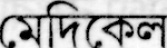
মেদিকেল
